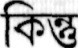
কিন্তু
